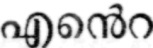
എന്റെ
